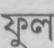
ফুল
